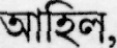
আহিল,
